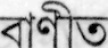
বাণীত
